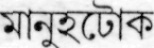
মানুহটোক
